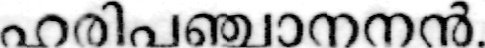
ഹരിപഞ്ചാനനന്‍.
